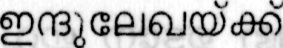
ഇന്ദുലേഖയ്ക്ക്
